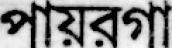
পায়রগা
